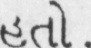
હતો.
